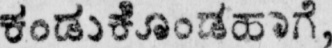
ಕಂಡುಕೊಂಡಹಾಗೆ,
